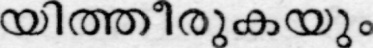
യിത്തീരുകയും
